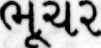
ભૂચર
